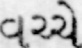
વચ્ચે
